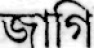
জাগি
